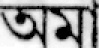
অমা
